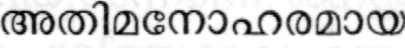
അതിമനോഹരമായ
